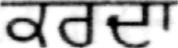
ਕਰਦਾ
